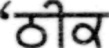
'ਠੀਕ
